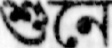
শুনে
